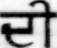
ਦੀ
